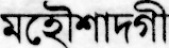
মহৌশাদগী
